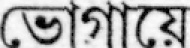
ভোগায়ে
